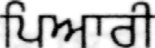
ਪਿਆਰੀ
